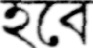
হবে
